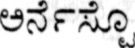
ಅರ್ನೆಸ್ಟೊ
